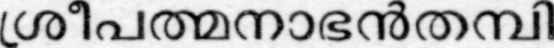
ശ്രീപത്മനാഭന്‍തമ്പി
